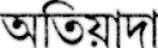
অতিয়াদা
